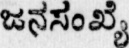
ಜನಸಂಖ್ಯೆ
